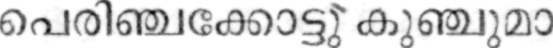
പെരിഞ്ചക്കോട്ടുകുഞ്ചുമാ
